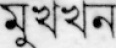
মুখখন
